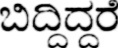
ಬಿದ್ದಿದ್ದರೆ
